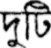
দুটি
